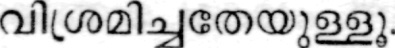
വിശ്രമിച്ചതേയുള്ളൂ.
